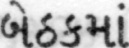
બેઠકમાં
